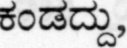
ಕಂಡದ್ದು,
